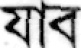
যাব
